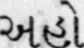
અહો
